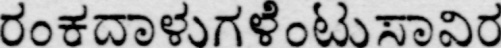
ರಂಕದಾಳುಗಳೆಂಟುಸಾವಿರ
